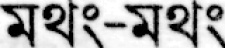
মথং-মথং
